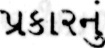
પ્રકારનું
